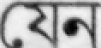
যেন
